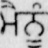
ਮੈਨੂੰ
